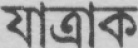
যাত্ৰাক
